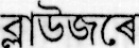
ব্লাউজৰে
